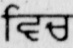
ਵਿਚ
